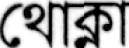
থোক্না
